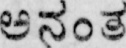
ಅನಂತ
